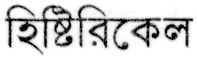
হিষ্টিরিকেল
